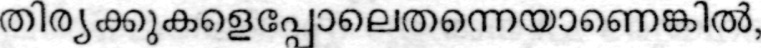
തിര്യക്കുകളെപ്പോലെതന്നെയാണെങ്കില്‍,
